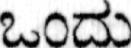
ಒಂದು
